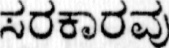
ಸರಕಾರವು
